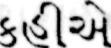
કહીએ
